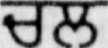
ਚਲ
